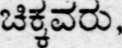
ಚಿಕ್ಕವರು,
